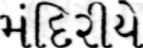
મંદિરીયે
